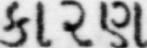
કારણ
